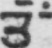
ਤੋਂ
